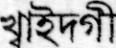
খ্বাইদগী
